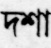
দশা
